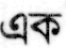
এক
